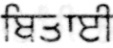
ਬਿਤਾਈ
